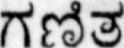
ಗಣಿತ
